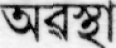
অৱস্হা
